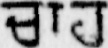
ਚਾਹ
